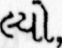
લ્યો,
